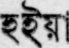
হইয়া
